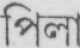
পিলা
